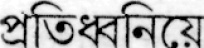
প্রতিধ্বনিয়ে
